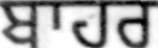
ਬਾਹਰ
